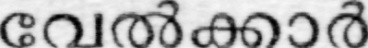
വേല്‍ക്കാര്‍
